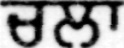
ਚਲਾ
